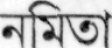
নমিতা
